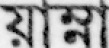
য়াম্না
